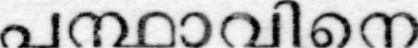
പന്ഥാവിനെ
